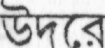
উদরে
